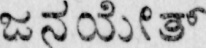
ಜನಯೇತ್
